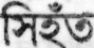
সিহঁত
